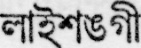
লাইশঙগী
